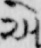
એ
